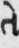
તે
